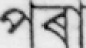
পৰা
